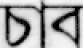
চাব
